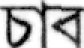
চাব
